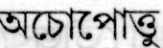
অচোপোত্তু
